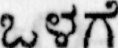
ಒಳಗೆ
